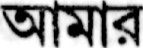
আমার
